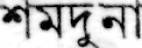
শমদুনা
